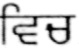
ਵਿਚ
